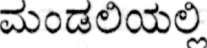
ಮಂಡಲಿಯಲ್ಲಿ
